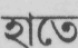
হাতে
